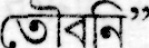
তৌবনি”
